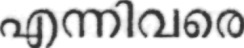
എന്നിവരെ
